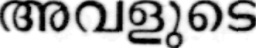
അവളുടെ
